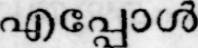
എപ്പോള്‍
